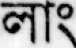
লাং
